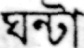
ঘন্টা
